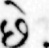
છે.
